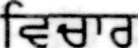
ਵਿਚਾਰ
